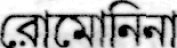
রোমোনিনা
